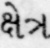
ક્ષેત્ર
